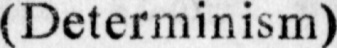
(Determinism)
